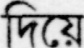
দিয়ে
